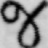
જ
